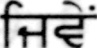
ਜਿਵੇਂ
